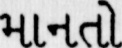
માનતો
